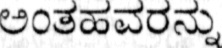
ಅಂತಹವರನ್ನು
